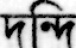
দন্দি
